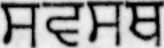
ਸਵਸਥ
